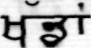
ਖੱਡਾਂ
